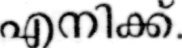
എനിക്ക്.
